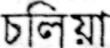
চলিয়া
